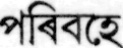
পৰিবহে
